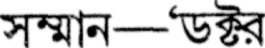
সম্মান-‘ডক্টর
